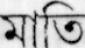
মাতি
